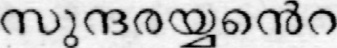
സുന്ദരയ്യന്റെ
